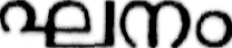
ഘനം
